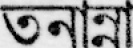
তনান্না
